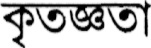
কৃতজ্ঞতা
